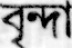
বৃন্দা
